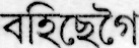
বহিছেগৈ
